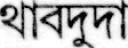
থাবদুদা
